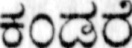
ಕಂಡರೆ
